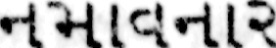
નમાવનાર
